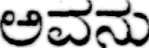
ಅವನು
